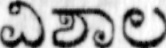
ವಿಶಾಲ
